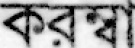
করম্বা
